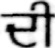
ਦੀ
